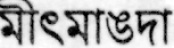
মীৎমাঙদা
